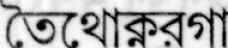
তৈথোক্নরগা
